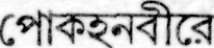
পোকহনবীরে
